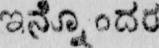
ಇನ್ನೊಂದರ
